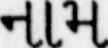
નામ
